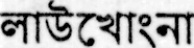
লাউখোংনা
